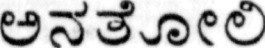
ಅನತೋಲಿ
